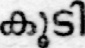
കൂടി
